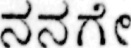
ನನಗೇ
